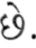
છે.
